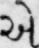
એ
